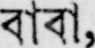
বাবা,
